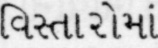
વિસ્તારોમાં
